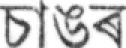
চাঙৰ
